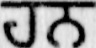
ਹਨ
